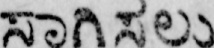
ಸಾಗಿಸಲು
